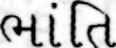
ભાંતિ
